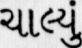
ચાલ્યું
